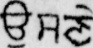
ਉਸਣੇ
